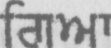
ਗਿਆ
